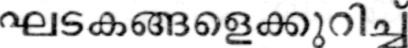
ഘടകങ്ങളെക്കുറിച്ച്
